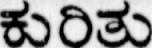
ಕುರಿತು
